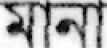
মানা
